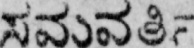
ಸಮವರ್ತಿ
